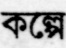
কল্পে
